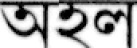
অহল
